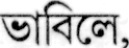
ভাবিলে,
